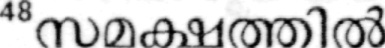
48സമക്ഷത്തില്‍
